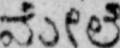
ಮೇಲೆ
